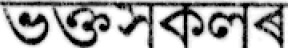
ভক্তসকলৰ
